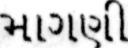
માગણી
